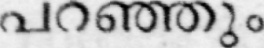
പറഞ്ഞും
